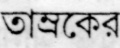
তাম্রকের
